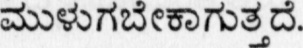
ಮುಳುಗಬೇಕಾಗುತ್ತದೆ.
